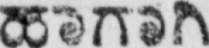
ಹಾಗಾಗಿ
